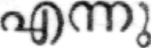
എന്നു
